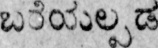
ಬರೆಯಲ್ಪಡ
